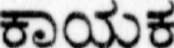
ಕಾಯಕ
